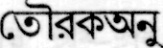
তৌরকঅনু
